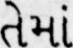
તેમાં
